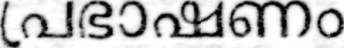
പ്രഭാഷണം
